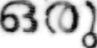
ഒരു
